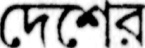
দেশের
